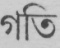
গতি
